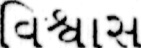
વિશ્વાસ
